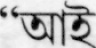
"আই
